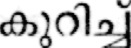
കുറിച്ച്
